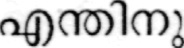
എന്തിനു
